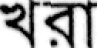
খরা
